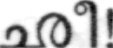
ഛീ!
